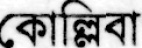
কোল্লিবা
